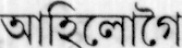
আহিলোগৈ
